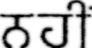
ਨਹੀਂ
